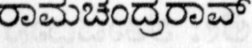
ರಾಮಚಂದ್ರರಾವ್
